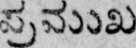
ಪ್ರಮುಖ
